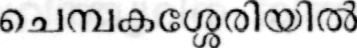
ചെമ്പകശ്ശേരിയില്‍
